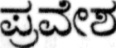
ಪ್ರವೇಶ
